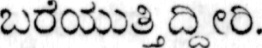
ಬರೆಯುತ್ತಿದ್ದೀರಿ.
